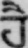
ਹੈ
